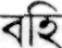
বহি
